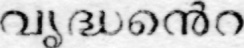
വൃദ്ധന്റെ
